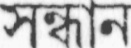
সন্ধান
